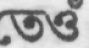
তেওঁ
